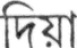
দিয়া
